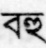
বহু
